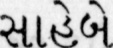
સાહેબે
